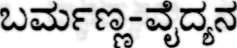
ಬರ್ಮಣ್ಣ-ವೈದ್ಯನ
